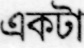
একটা
